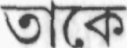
তাকে
